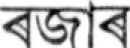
ৰজাৰ
